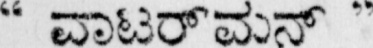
“ವಾಟರ್ಮನ್”
